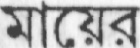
মায়ের
